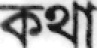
কথা
